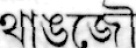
থাঙজৌ
